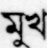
মুখ
